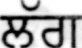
ਲੱਗ
